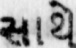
સાથે
